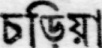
চড়িয়া
